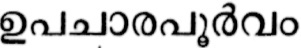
ഉപചാരപൂര്‍വം
